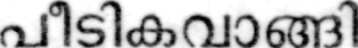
പീടികവാങ്ങി
